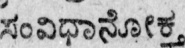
ಸಂವಿಧಾನೋಕ್ತ
